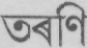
তৰণি
